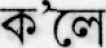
ক'লে
